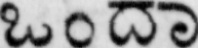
ಒಂದಾ
